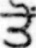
ਤੋਂ
